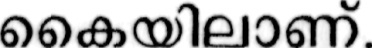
കൈയിലാണ്.
